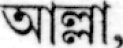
আল্লা,
